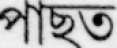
পাছত
